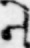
ને
